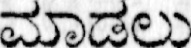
ಮಾಡಲು
